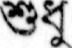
শুধু
